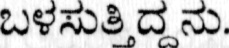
ಬಳಸುತ್ತಿದ್ದನು.
